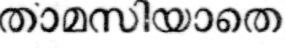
താമസിയാതെ
